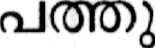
പത്തു
